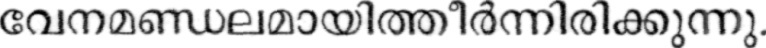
വേനമണ്ഡലമായിത്തീര്‍ന്നിരിക്കുന്നു.
